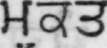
ਮੁਕਤ
